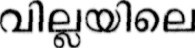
വില്ലയിലെ
